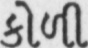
કોળી
